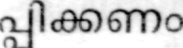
പ്പിക്കണം
